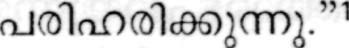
പരിഹരിക്കുന്നു."
